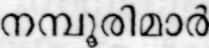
നമ്പൂരിമാര്‍
